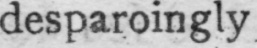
desparoingly
